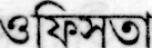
ওফিসতা
